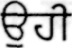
ਉਹੀ
